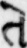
તે
